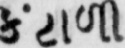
કંટાળી
